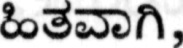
ಹಿತವಾಗಿ,
